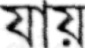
যায়
